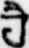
ਹੈ
